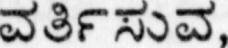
ವರ್ತಿಸುವ,
